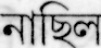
নাছিল
